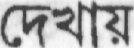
দেখায়
